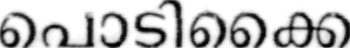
പൊടിക്കൈ
